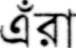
এঁরা
